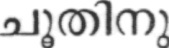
ചൂതിനു
